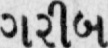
ગરીબ
